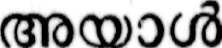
അയാള്‍
